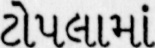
ટોપલામાં
